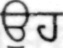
ਉਹ
